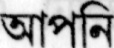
আপনি
